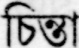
চিন্তা
